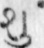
શું
